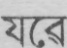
যৱে
